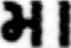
મા
